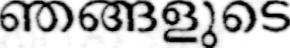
ഞങ്ങളുടെ
